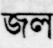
জল
